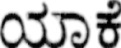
ಯಾಕೆ
